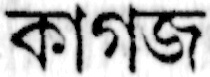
কাগজ
